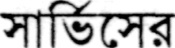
সার্ভিসের
